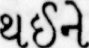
થઈને
